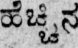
ಹೆಚ್ಚಿನ
